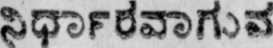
ನಿರ್ಧಾರವಾಗುವ
